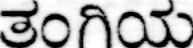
ತಂಗಿಯ
